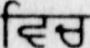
ਵਿਚ
